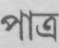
পাত্ৰ
